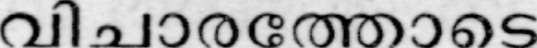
വിചാരത്തോടെ
